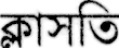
ক্লাসতি
